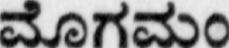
ಮೊಗಮಂ
